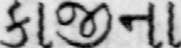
કાજીના
